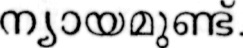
ന്യായമുണ്ട്.
